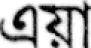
এয়া
